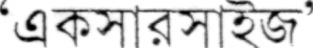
‘একসারসাইজ’
